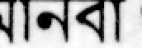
মানবা
